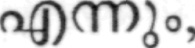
എന്നും,
